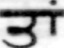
ਤਾਂ
